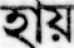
হায়
